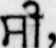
ਸੀ,
